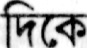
দিকে
